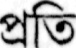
প্রতি
